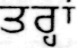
ਤਰ੍ਹਾਂ
